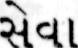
સેવા
